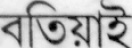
বতিয়াই
